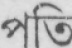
পতি
